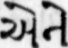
એને
